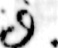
છે.
